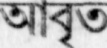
আবৃত
